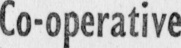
Co-operative
